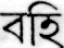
বহি
